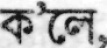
ক'লে,
